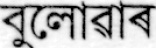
বুলোৱাৰ
